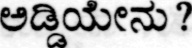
ಅಡ್ಡಿಯೇನು?
